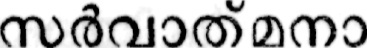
സര്‍വാത്മനാ
